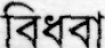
বিধবা
